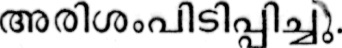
അരിശംപിടിപ്പിച്ചു.
